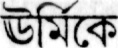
ঊর্মিকে
